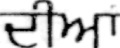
ਦੀਆਂ
